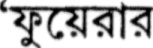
'ফুয়েরার
